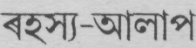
ৰহস্য-আলাপ
